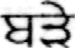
ਬੜੇ
